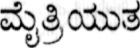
ಮೈತ್ರಿಯುತ
